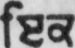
ਇਕ
